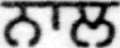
ਨਾਲ
